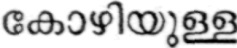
കോഴിയുള്ള
